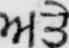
ਅਤੇ
